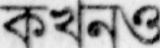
কখনও
